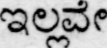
ಇಲ್ಲವೇ
